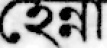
হেন্না
